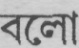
বলো
